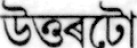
উত্তৰটো
